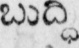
ಬುದ್ಧಿ
